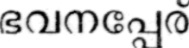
ഭവനപ്പേര്
